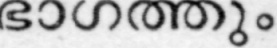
ഭാഗത്തും
